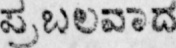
ಪ್ರಬಲವಾದ
